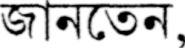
জানতেন,
